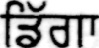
ਡਿੱਗਾ
